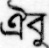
ঐবু
